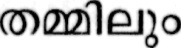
തമ്മിലും
